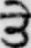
ਤੇ
